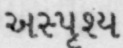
અસ્પૃશ્ય
